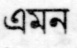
এমন
